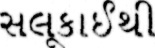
સલૂકાઈથી
